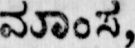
ಮಾಂಸ,
